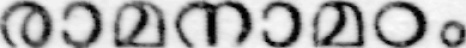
രാമനാമഠം
